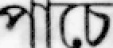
পাচে
